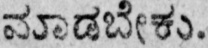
ಮಾಡಬೇಕು.
